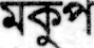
মকুপ
